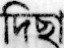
দিছা
